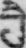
ਹੈ
